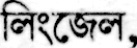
লিংজেল,
